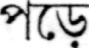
পড়ে
